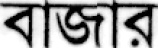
বাজার
